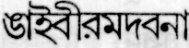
ঙাইবীরমদবনা
